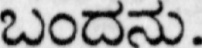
ಬಂದನು.
